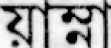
য়াম্না
